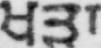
ਖੜਾ
